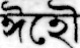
ঈহৌ
